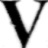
V
